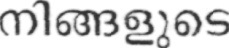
നിങ്ങളുടെ
